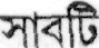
সাবটি
